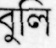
বুলি
